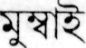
মুম্বাই
